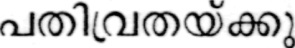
പതിവ്രതയ്ക്കു
